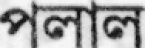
পলাল
